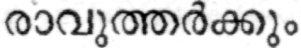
രാവുത്തര്‍ക്കും
